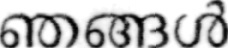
ഞങ്ങള്‍
